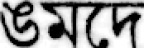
ঙমদে
